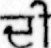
ਦੀ
